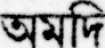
অমদি
